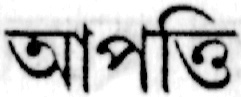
আপত্তি
